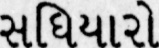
સધિયારો
